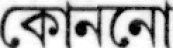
কোননো
